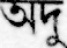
অদু
